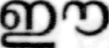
ഈ
